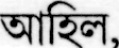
আহিল,
